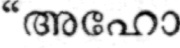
“അഹോ
